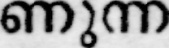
ണുന്ന
